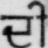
ਦੀ
